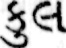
કુલ
